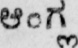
ಆ೦ಗ್ಲ
